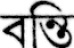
বন্তি
